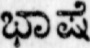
ಭಾಷೆ
